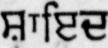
ਸ਼ਾਇਦ
